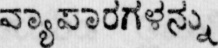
ವ್ಯಾಪಾರಗಳನ್ನು
